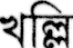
খল্লি
